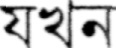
যখন
